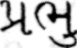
પ્રભુ
